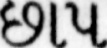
છાપ
